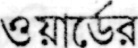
ওয়ার্ডের
